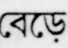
বেড়ে
